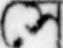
সে
